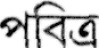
পবিত্র
